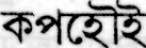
কপহৌই
